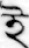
ই
